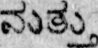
ಮತ್ತು
